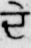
ਦੇ
